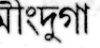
মীংদুগা
